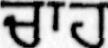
ਚਾਹ
